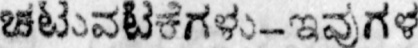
ಚಟುವಟಿಕೆಗಳು-ಇವುಗಳ
